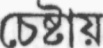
চেষ্টায়
